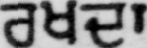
ਰਖਦਾ
